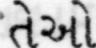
તેઓ
